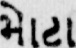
મોટા
